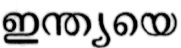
ഇന്ത്യയെ
